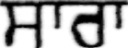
ਸਾਰਾ
